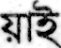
য়াই
